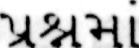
પ્રશ્નમાં
